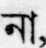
না,
